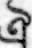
ঐ
